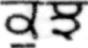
ਕੁਝ
